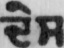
ਦੇਸ
